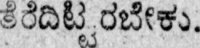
ತೆರೆದಿಟ್ಟಿರಬೇಕು.
